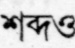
শব্দও
